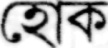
হোক
